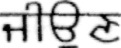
ਜੀਉਣ
